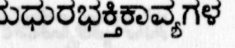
ಮಧುರಭಕ್ತಿಕಾವ್ಯಗಳ
